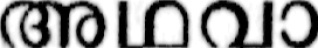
അഥവാ
